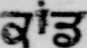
ਕਾਂਡ
